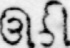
ઊઠી
